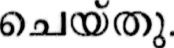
ചെയ്തു.
